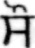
ਸੌ
